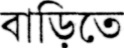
বাড়িতে
